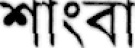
শাংবা
